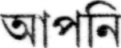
আপনি
